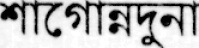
শাগোন্নদুনা
